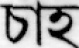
চাহ
